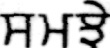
ਸਮਝੇ
